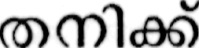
തനിക്ക്
